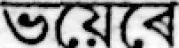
ভয়েৰে
